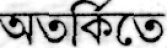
অতর্কিতে
